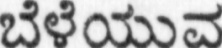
ಬೆಳೆಯುವ
